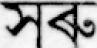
সৰু
